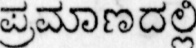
ಪ್ರಮಾಣದಲ್ಲಿ
